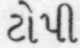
ટોપી
